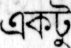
একটু
